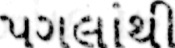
પગલાંથી
